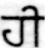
ਹੀ
